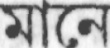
মানে
